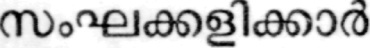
സംഘക്കളിക്കാര്‍
